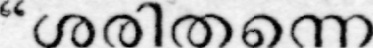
"ശരിതന്നെ
